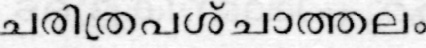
ചരിത്രപശ്ചാത്തലം
